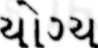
યોગ્ય
